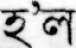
হ'ল
